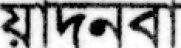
য়াদনবা
